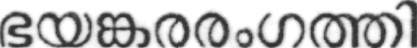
ഭയങ്കരരംഗത്തി
